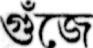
গুঁজে
